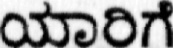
ಯಾರಿಗೆ
